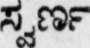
ಸ್ವರ್ಣ
